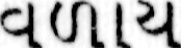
વળાય
